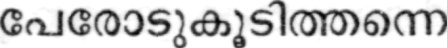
പേരോടുകൂടിത്തന്നെ
